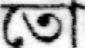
তো
